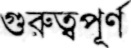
গুরুত্বপূর্ণ
